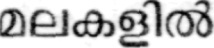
മലകളില്‍
